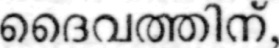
ദൈവത്തിന്,
